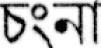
চংনা
